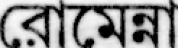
রোমেন্না
